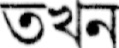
তখন
